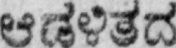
ಆಡಳಿತದ
